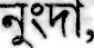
নুংদা,
